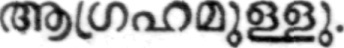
ആഗ്രഹമുള്ളു.
